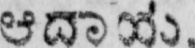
ಆದಾಯ.
